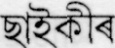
ছাইকীৰ
